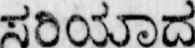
ಸರಿಯಾದ
